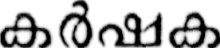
കര്‍ഷക
